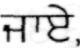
ਜਾਏ,
